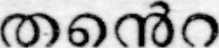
തന്റെ
